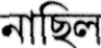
নাছিল
